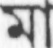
মা
